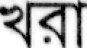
খরা
